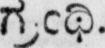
ಗ್ರಂಥಿ.
